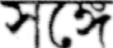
সঙ্গে
